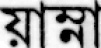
য়াম্না
